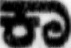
ಕಾ
